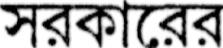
সরকারের
